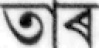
তাৰ
